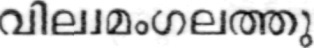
വില്വമംഗലത്തു
